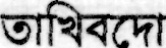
তাখিবদো
